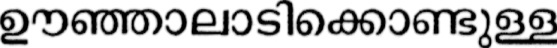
ഊഞ്ഞാലാടിക്കൊണ്ടുള്ള
